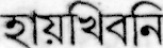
হায়খিবনি
